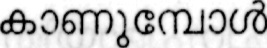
കാണുമ്പോള്‍
